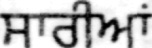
ਸਾਰੀਆਂ
